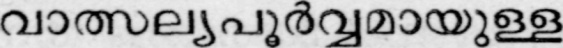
വാത്സല്യപൂര്‍വ്വമായുള്ള
